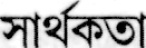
সার্থকতা
